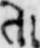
તો
